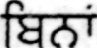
ਬਿਨਾਂ
